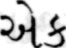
એક
